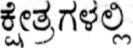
ಕ್ಷೇತ್ರಗಳಲ್ಲಿ
